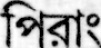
পিরাং
